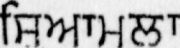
ਸ਼ਿਆਮਲਾ
